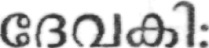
ദേവകി:
